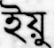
ইয়ু
